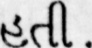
હતી.
